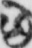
છે
